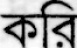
করি
